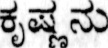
ಕೃಷ್ಣನು
